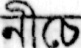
নীচে
